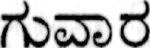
ಗುವಾರ
